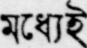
মধ্যেই
